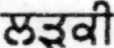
ਲੜਕੀ
